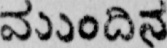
ಮುಂದಿನ
